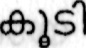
കൂടി
